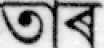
তাৰ
